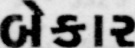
બેકાર
